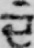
ਦੇ
